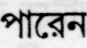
পারেন
